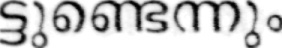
ട്ടുണ്ടെന്നും
